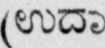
(ಉದಾ
